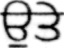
ਉਤੇ
